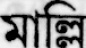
মাল্লি
